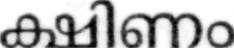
ക്ഷിണം
